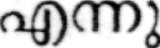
എന്നു
